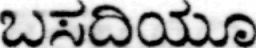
ಬಸದಿಯೂ
